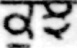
ਕੁਝ
